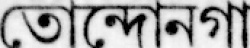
তোন্দোনগা
